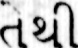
તેથી
